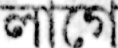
লাগে
